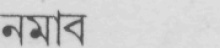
নমাব
